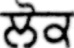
ਲੋਕ
